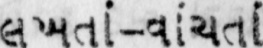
લખતાં-વાંચતા
